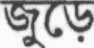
জুড়ে
